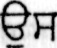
ਉਸ
